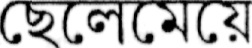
ছেলেমেয়ে
